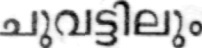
ചുവട്ടിലും
